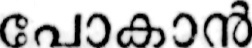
പോകാന്‍
